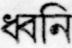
ধ্বনি
